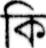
কি
